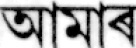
আমাৰ
